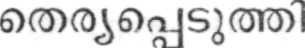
തെര്യപ്പെടുത്തി
